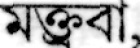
মক্ত্রবা,
